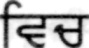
ਵਿਚ
